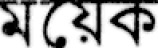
ময়েক
